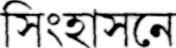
সিংহাসনে
